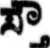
ಸ್ತೌ
